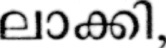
ലാക്കി,
